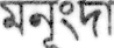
মনূংদা
